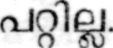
പറ്റില്ല.
